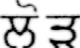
ਲੋੜ
